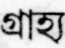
গ্রাহ্য
